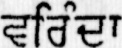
ਵਰਿੰਦਾ
